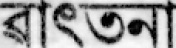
ৱাৎতনা
